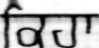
ਕਿਹਾ
